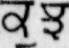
ਕੁਝ
